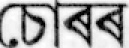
চোৰৰ
